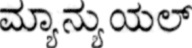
ಮ್ಯಾನ್ಯುಯಲ್
